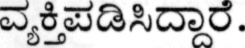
ವ್ಯಕ್ತಿಪಡಿಸಿದ್ದಾರೆ.
